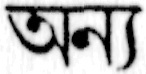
অন্য
